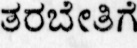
ತರಬೇತಿಗೆ
